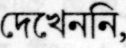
দেখেননি,
